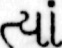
ત્યાં
